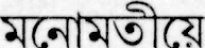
মনোমতীয়ে
